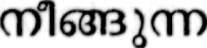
നീങ്ങുന്ന
